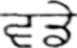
ਵਡੇ
